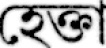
হেক্তা
